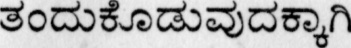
ತಂದುಕೊಡುವುದಕ್ಕಾಗಿ
